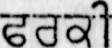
ਫਰਕੀ
